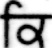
ਕਿ
